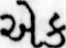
એક
